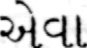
એવા
